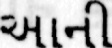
આની
